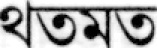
থতমত
